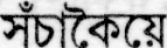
সঁচাকৈয়ে
